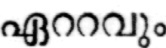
ഏററവും
